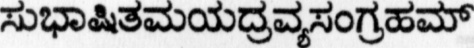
ಸುಭಾಷಿತಮಯದ್ರವ್ಯಸ೦ಗ್ರಹಮ್
